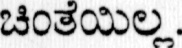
ಚಿಂತೆಯಿಲ್ಲ.
